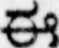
ಈ
